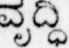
ವೃದ್ಧಿ
